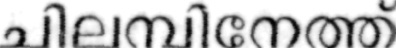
ചിലമ്പിനേത്ത്
